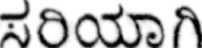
ಸರಿಯಾಗಿ
